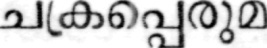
ചക്രപ്പെരുമ
